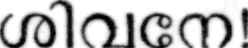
ശിവനേ!
